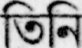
তিনি
